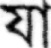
যা
